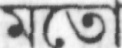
মতো
